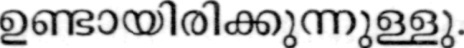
ഉണ്ടായിരിക്കുന്നുള്ളു.
